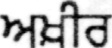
ਅਖ਼ੀਰ
